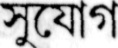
সুযোগ
